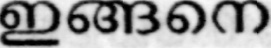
ഇങ്ങനെ
